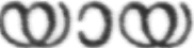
യായ
